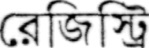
রেজিস্ট্রি
